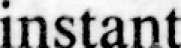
instant
